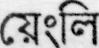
য়েংলি
